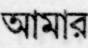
আমার
